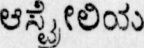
ಆಸ್ಟ್ರೇಲಿಯ
